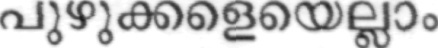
പുഴുക്കളെയെല്ലാം
